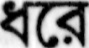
ধরে
